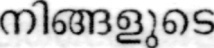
നിങ്ങളുടെ
